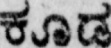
ಕೂಡ
